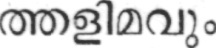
ത്തളിമവും
